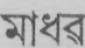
মাধৱ
